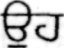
ਉਹ
